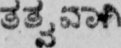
ತತ್ವವಾಗಿ
